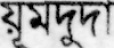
য়ূমদুদা
